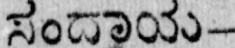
ಸಂದಾಯ-
